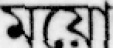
ময়ো
